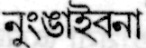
নুংঙাইবনা
